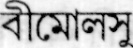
বীমোলসু
